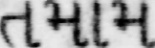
તમામ
